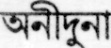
অনীদুনা
